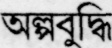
অল্পবুদ্ধি
